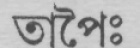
তাপৈঃ
